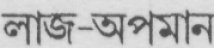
লাজ-অপমান
